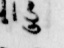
થોડું
